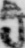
ਹੈ
